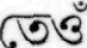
তেওঁ
